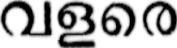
വളരെ
